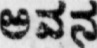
ಅವನ
